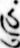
હું
